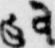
હવે
